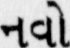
નવો
